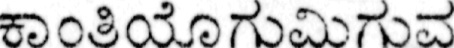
ಕಾಂತಿಯೊಗುಮಿಗುವ
